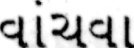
વાંચવા
